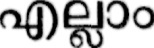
എല്ലാം
